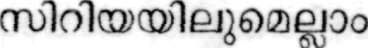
സിറിയയിലുമെല്ലാം
